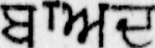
ਬਾਅਦ
